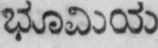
ಭೂಮಿಯ
